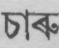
চাৰু
